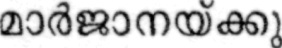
മാര്‍ജാനയ്ക്കു
